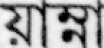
য়াম্না
